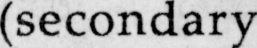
(Secondary
